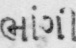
ભાંગી
